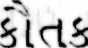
કૌતક
